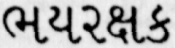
ભયરક્ષક
